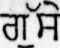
ਗੁੱਸੇ
